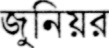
জুনিয়র
